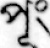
পূং
